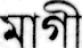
মাগী
